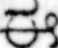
ಈ
